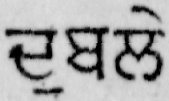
ਦੁਬਲੇ
